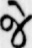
જે
